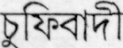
চুফিবাদী
